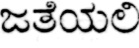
ಜತೆಯಲಿ
